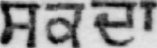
ਸਕਦਾ
